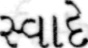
સ્વાદે
